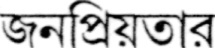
জনপ্রিয়তার
